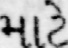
માટે
